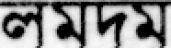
লমদম
